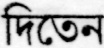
দিতেন
